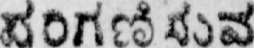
ಪರಿಗಣಿಸುವ
